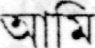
আমি
